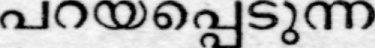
പറയപ്പെടുന്ന
